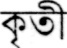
কৃতী
